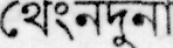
থেংনদুনা
